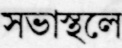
সভাস্থলে
